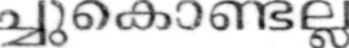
ച്ചുകൊണ്ടല്ല
